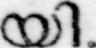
യി.
